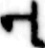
ન
